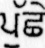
ਪੁੱਛੇ
